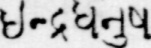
ઈન્દ્રધનુષ
